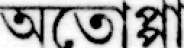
অতোপ্পা
